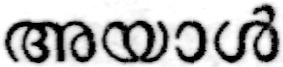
അയാള്‍
